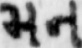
મન
